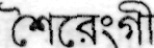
শৈরেংগী
